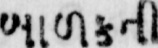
બાળકની
